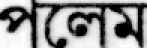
পলেম
